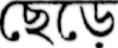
ছেড়ে
